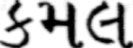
કમલ
